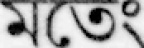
মতেং
